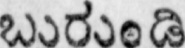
ಬುರುಂಡಿ
